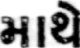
માથે
